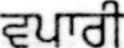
ਵਪਾਰੀ
